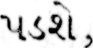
પડશે,
